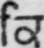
ਕਿ
